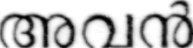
അവന്‍
